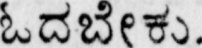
ಓದಬೇಕು.
